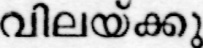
വിലയ്ക്കു
